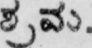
ಶ್ರಮ.
